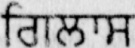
ਗਿਲਾਸ
